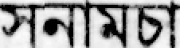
সনামচা
